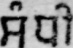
ਸੰਧੀ
